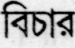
বিচার
